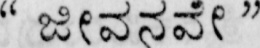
“ಜೀವನವೇ”
